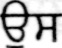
ਉਸ
